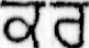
ਕਰ
